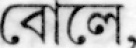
বোলে,
